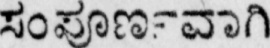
ಸಂಪೂರ್ಣವಾಗಿ
